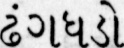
ઢંગધડો
